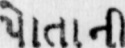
પોતાની
